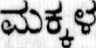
ಮಕ್ಕಳ
